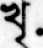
খৃ.
